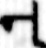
ન
